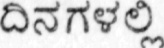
ದಿನಗಳಲ್ಲಿ
